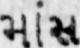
માંસ
